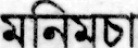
মনিমচা
